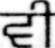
ਵੀ
